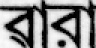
ৱারা
